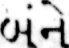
બંને
